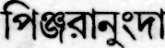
পিঞ্জরানুংদা
